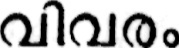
വിവരം
